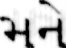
મને
